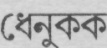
ধেনুকক
